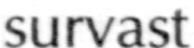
survast
